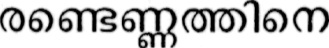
രണ്ടെണ്ണത്തിനെ
